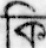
কি
